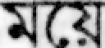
ময়ে
